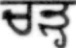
ਚੜ੍ਹ
